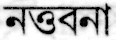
নত্তবনা
